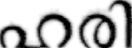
ഹരി
